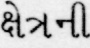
ક્ષેત્રની
